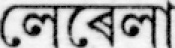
লেৰেলা
